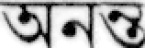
অনন্ত
